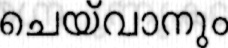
ചെയ്വാനും
